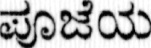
ಪೂಜೆಯ
